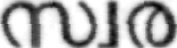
സ്വര
